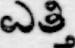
ಎತ್ತಿ
